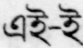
এই-ই
